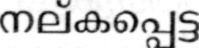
നല്കപ്പെട്ട
